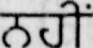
ਨਹੀਂ
